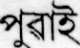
পুৱাই
